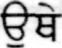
ਉਥੇ
